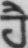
ਹੈ
